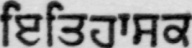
ਇਤਿਹਾਸਕ
